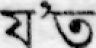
য'ত
